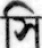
সি
